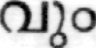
വും
